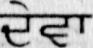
ਦੇਵਾ
